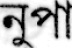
নুপা
